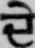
ਦੇ
